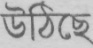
উঠিছে
